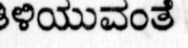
ತಿಳಿಯುವಂತೆ
